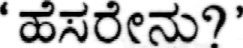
'ಹೆಸರೇನು?'
